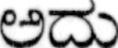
ಅದು
